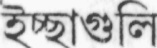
ইচ্ছাগুলি
